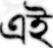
এই
